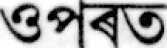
ওপৰত
